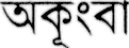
অকূংবা
